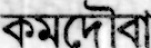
কমদৌবা
